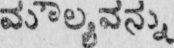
ಮೌಲ್ಯವನ್ನು
